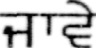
ਜਾਵੇ
